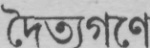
দৈত্যগণে
